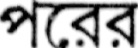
পরের
